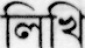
লিখি
